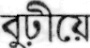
বুঢ়ীয়ে
